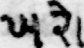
ખરો
